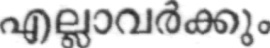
എല്ലാവര്‍ക്കും
